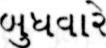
બુધવારે
